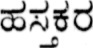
ಹಸ್ತಕರ
